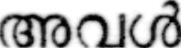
അവള്‍
